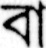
বা
